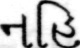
નહિ
